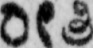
ರೀತಿ
